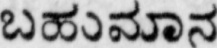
ಬಹುಮಾನ
